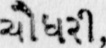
ચૌધરી,
